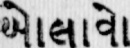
બોલાવો
